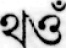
থওঁ
